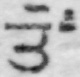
ਤੋਂ
